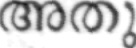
അതു
